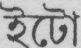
ইটো
